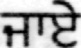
ਜਾਏ
